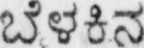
ಬೆಳಕಿನ
